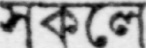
সকলে
